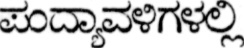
ಪಂದ್ಯಾವಳಿಗಳಲ್ಲಿ
